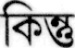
কিন্তু
